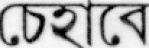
চেহাবে
